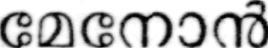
മേനോന്‍
